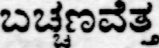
ಬಚ್ಚಣವೆತ್ತ
